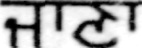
ਜਾਣਾ
